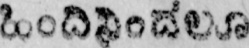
ಹಿಂದಿನಿಂದಲೂ
